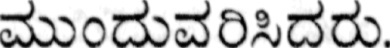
ಮುಂದುವರಿಸಿದರು.
